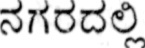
ನಗರದಲ್ಲಿ
